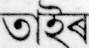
তাইৰ
